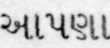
આપણા
